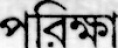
পরিক্ষা
